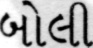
બોલી
